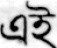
এই
